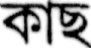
কাছ
